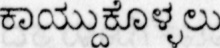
ಕಾಯ್ದುಕೊಳ್ಳಲು
